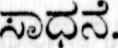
ಸಾಧನೆ.
